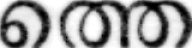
ത്തെ
